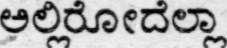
ಅಲ್ಲಿರೋದೆಲ್ಲಾ
